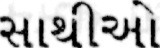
સાથીઓ
